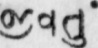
જીવતું
